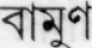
বামুণ
